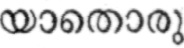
യാതൊരു
